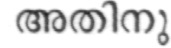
അതിനു
